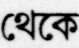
থেকে
